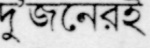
দু’জনেরই
